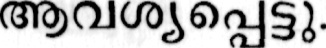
ആവശ്യപ്പെട്ടു.
